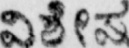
ವಿಶೇಷ
